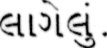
લાગેલું.
